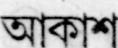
আকাশ
